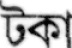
টকা
